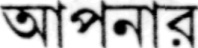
আপনার
